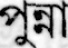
পুন্না
